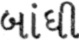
બાંધી
